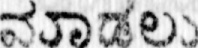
ಮಾಡಲು
